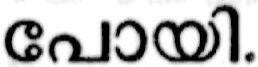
പോയി.
